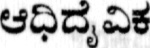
ಆಧಿದೈವಿಕ
